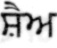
ਸ਼ੈਅ
